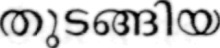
തുടങ്ങിയ
